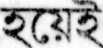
হয়েই
